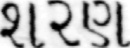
શરણ
